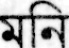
মনি
